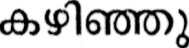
കഴിഞ്ഞു
